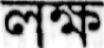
লক্ষ
